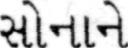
સોનાને
